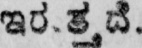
ಇರುತ್ತದೆ.
